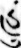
હું
